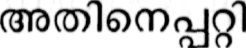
അതിനെപ്പറ്റി
